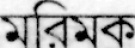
মরিমক
